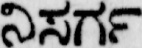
ನಿಸರ್ಗ
